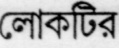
লোকটির
